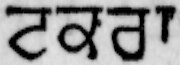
ਟਕਰਾ
